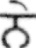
ਨੇ
